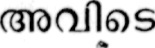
അവിടെ
